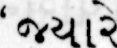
'જ્યારે
